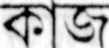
কাজ
